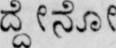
ದ್ದೇನೋ
